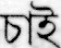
চাই
